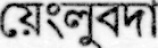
য়েংলুবদা
